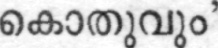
കൊതുവും'
